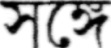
সঙ্গে
